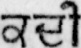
ਕਦੀ
